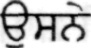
ਉਸਨੇ
